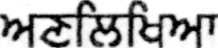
ਅਣਲਿਖਿਆ
